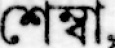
শেম্বা,
